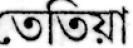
তেতিয়া
